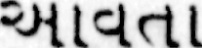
આવતા
